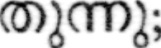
തുന്നു;
